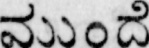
ಮುಂದೆ
